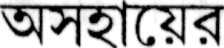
অসহায়ের
